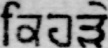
ਕਿਹੜੇ
